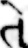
તે
